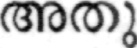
അതു
